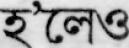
হ'লেও
